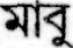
মাবু
